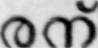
രന്
